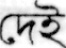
দেই
